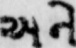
અને
